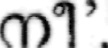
നീ',
